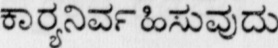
ಕಾರ್‍ಯನಿರ್ವಹಿಸುವುದು
